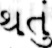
થતું
